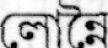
লোন্নৈ
